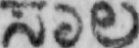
ಸಾಲ
